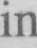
in
